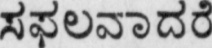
ಸಫಲವಾದರೆ
